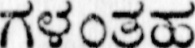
ಗಳಂತಹ
